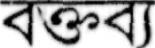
বক্তব্য
